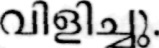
വിളിച്ചു.
